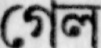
গেল
